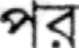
পর
